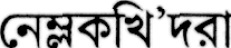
নেম্লকখি’দরা
